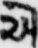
એ
